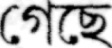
গেছে
